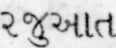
રજુઆત
